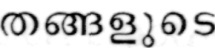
തങ്ങളുടെ
